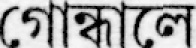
গোন্ধালে
